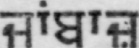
ਜਾਂਬਾਜ਼
